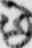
છે
